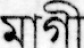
মাগী
